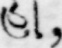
હા,
